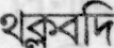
থক্লবদি
